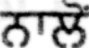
ਨਾਲੋਂ
